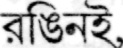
রঙিনই,
